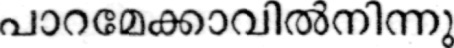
പാറമേക്കാവില്‍നിന്നു
